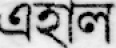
এহাল
